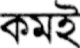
কমই
